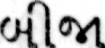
બીજા
